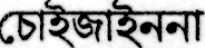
চোইজাইননা
